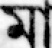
মা
